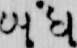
બંધ
